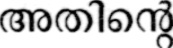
അതിന്റെ
